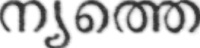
ന്യത്തെ
